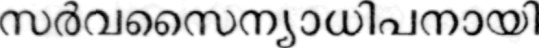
സര്‍വസൈന്യാധിപനായി
